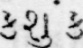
કશુંક
